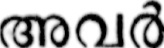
അവര്‍
